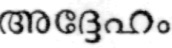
അദ്ദേഹം
